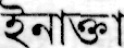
ইনাক্তা
